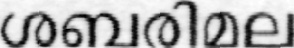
ശബരിമല
